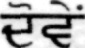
ਦੋਵੇਂ
